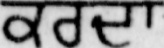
ਕਰਦਾ
